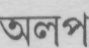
অলপ
